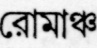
রোমাঞ্চ
